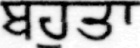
ਬਹੁਤਾ
